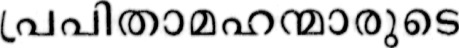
പ്രപിതാമഹന്മാരുടെ
